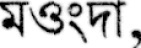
মওংদা,
